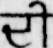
ਦੀ
